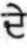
ਦੇ
